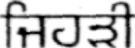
ਜਿਹੜੀ
